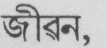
জীৱন,
